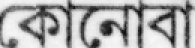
কোনোবা
